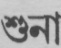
শুনা
